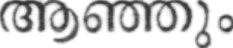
ആഞ്ഞും
